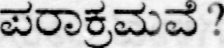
ಪರಾಕ್ರಮವೆ?
